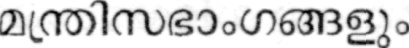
മന്ത്രിസഭാംഗങ്ങളും
